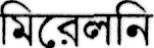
মিরেলনি
